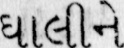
ઘાલીને
